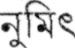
নুমিৎ
